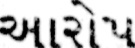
આરોપ
